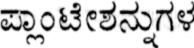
ಪ್ಲಾಂಟೇಶನ್ನುಗಳ
